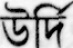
উর্দি
